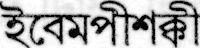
ইবেমপীশক্কী
